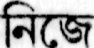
নিজে
